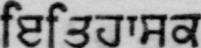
ਇਤਿਹਾਸਕ
